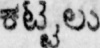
ಕಟ್ಟಲು
